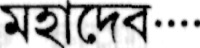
মহাদেব....
